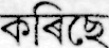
কৰিছে
